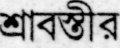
শ্রাবস্তীর
